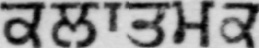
ਕਲਾਤਮਕ
